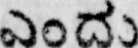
ಎಂದು
